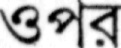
ওপর
